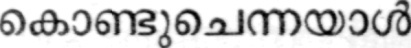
കൊണ്ടുചെന്നയാള്‍
